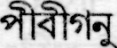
পীবীগনু
